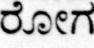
ರೋಗ
